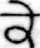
ਕੇ
